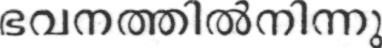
ഭവനത്തില്‍നിന്നു
